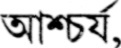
আশ্চর্য,
